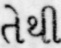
તેથી
